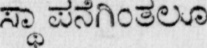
ಸ್ಥಾಪನೆಗಿಂತಲೂ
